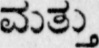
ಮತ್ತು
